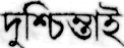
দুশ্চিন্তাই
